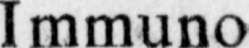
Immuno
